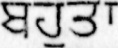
ਬਹੁਤਾ
